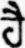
ਹੈ
